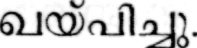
ഖയ്പിച്ചു.
